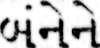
બંનેને
